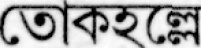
তোকহল্লে
